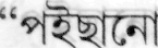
"পইছানো
